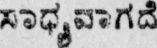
ಸಾಧ್ಯವಾಗದೆ
